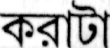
করাটা
